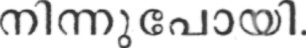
നിന്നുപോയി.
